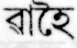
ৱাহৈ
